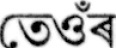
তেওঁৰ
